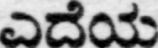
ಎದೆಯ
